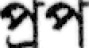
প্রপ
